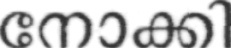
നോക്കി
